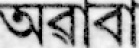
অৱাবা
